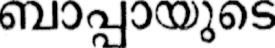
ബാപ്പായുടെ
